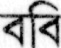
ববি
